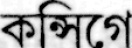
কন্সিগে
